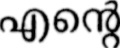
എന്റെ
